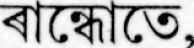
ৰান্ধোতে,
